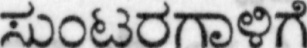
ಸುಂಟರಗಾಳಿಗೆ
